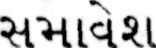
સમાવેશ
